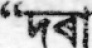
"দৰা
